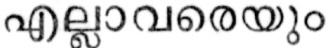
എല്ലാവരെയും
